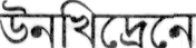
উনখিদ্রেনে
